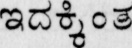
ಇದಕ್ಕಿಂತ
